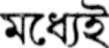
মধ্যেই
